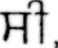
ਸੀ,
